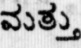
ಮತ್ತು
